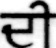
ਦੀ
